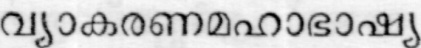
വ്യാകരണമഹാഭാഷ്യ
